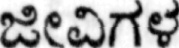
ಜೀವಿಗಳ
